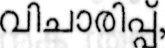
വിചാരിപ്പ്,
